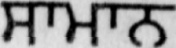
ਸਾਮਾਨ
